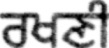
ਰਖਣੀ
